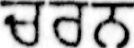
ਚਰਨ
